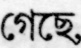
গেছে,
